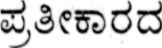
ಪ್ರತೀಕಾರದ
